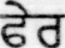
ਫੇਰ
